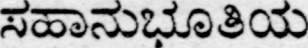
ಸಹಾನುಭೂತಿಯ
